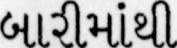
બારીમાંથી
